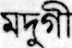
মদুগী
